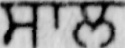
ਸਾਲ
